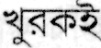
খুরকই
